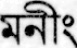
মনীং
